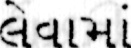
લેવામાં
